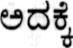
ಅದಕ್ಕೆ
